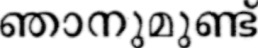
ഞാനുമുണ്ട്
